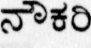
ನೌಕರಿ
